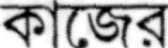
কাজের
